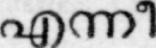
എന്നീ
